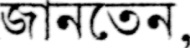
জানতেন,
